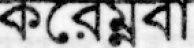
করেম্নবা
